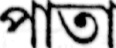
পাতা
